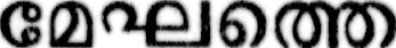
മേഘത്തെ
